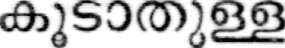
കൂടാതുള്ള
